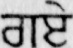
ਗਏ
